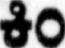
ಕಿಂ
